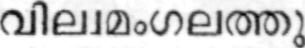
വില്വമംഗലത്തു
